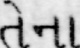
તેના
